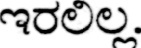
ಇರಲಿಲ್ಲ.
